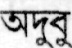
অদুবু
